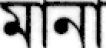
মানা
